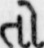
તો
